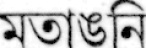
মতাঙনি
